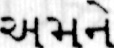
અમને
